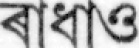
ৰাধাও
